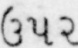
ઉપર
